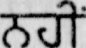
ਨਹੀਂ
